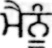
ਮੈਨੂੰ
